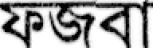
ফজবা
